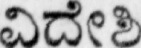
ವಿದೇಶಿ
